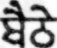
ਬੈਠੇ
